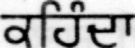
ਕਹਿੰਦਾ
